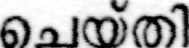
ചെയ്തി
